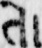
તો
